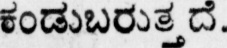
ಕಂಡುಬರುತ್ತದೆ.
